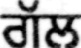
ਗੱਲ
